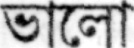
ভালো
